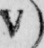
v)
